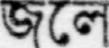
জলে
